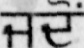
ਜਦੋਂ
